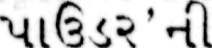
પાઉડર'ની
